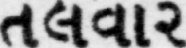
તલવાર
